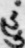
હું
